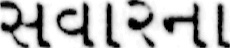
સવારના
